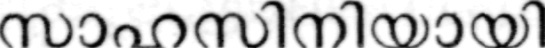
സാഹസിനിയായി
